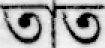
তাত
